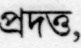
প্রদত্ত,
